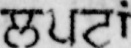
ਲਪਟਾਂ
